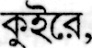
কুইরে,
